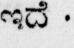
ಇದೆ.
